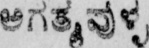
ಅಗತ್ಯವುಳ್ಳ
